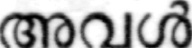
അവള്‍
